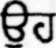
ਉਹ
